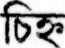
চিহ্ন
